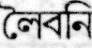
লৈবনি
